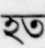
হত
